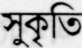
সুকৃতি
